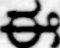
ಈ
